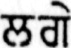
ਲਗੇ
